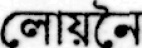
লোয়নৈ
